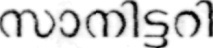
സാനിട്ടറി
